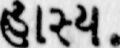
હાસ્ય.
